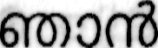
ഞാന്‍
